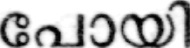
പോയി
